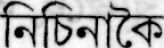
নিচিনাকৈ
